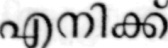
എനിക്ക്
